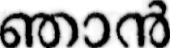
ഞാന്‍
